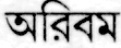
অরিবম
